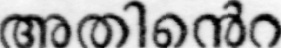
അതിന്റെ
